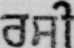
ਰਸੀ
